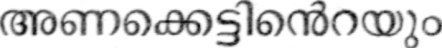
അണക്കെട്ടിന്റെയും
